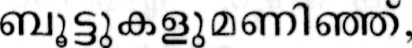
ബൂട്ടുകളുമണിഞ്ഞ്,
